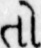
તો
